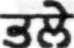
ਭਲੇ
